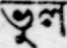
ভুল
